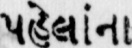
પહેલાંના
